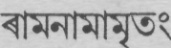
ৰামনামামৃতং
